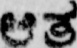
ಆತ
